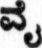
ವೈ
